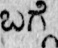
ಬಗ್ಗೆ
